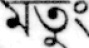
মতুং
